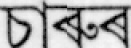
চাৰুৰ
